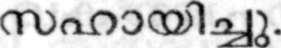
സഹായിച്ചു.
